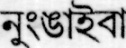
নুংঙাইবা
